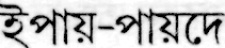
ইপায়-পায়দে
